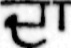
ਦਾ
